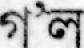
গ'ল
